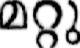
മറ്റു
